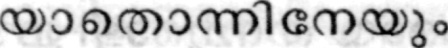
യാതൊന്നിനേയും
